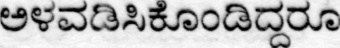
ಅಳವಡಿಸಿಕೊಂಡಿದ್ದರೂ
